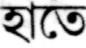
হাতে
